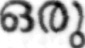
ഒരു
